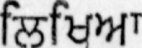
ਲਿਖਿਆ
